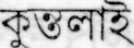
কুন্তলাই
